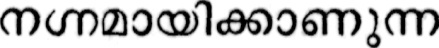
നഗ്നമായിക്കാണുന്ന
